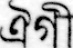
ঐগী
